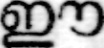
ഈ
